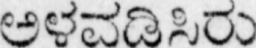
ಅಳವಡಿಸಿರು
